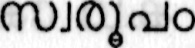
സ്വരൂപം
